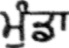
ਮੁੰਡਾ
